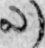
ಎ)
